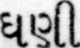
ઘણી
